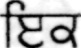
ਇਕ
